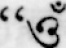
"ওঁ
